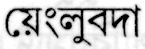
য়েংলুবদা
